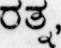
ರತ್ನ,
